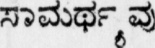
ಸಾಮರ್ಥ್ಯವು
